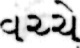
વચ્ચે
